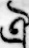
ঐ
